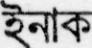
ইনাক
